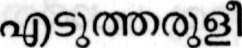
എടുത്തരുളീ
